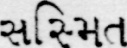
સસ્મિત
